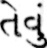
તેવું
